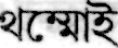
থম্মোই
